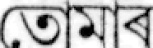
তোমাৰ
